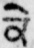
ਕੇ
